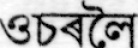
ওচৰলৈ
